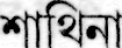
শাথিনা
